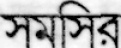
সমসির
